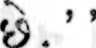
છે."
